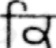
ਕਿ
